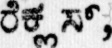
ರೆಕ್ಲಸ್,
